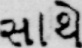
સાથે
